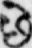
છે
